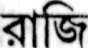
রাজি
